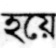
হয়ে
